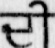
ਦੀ
